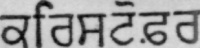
ਕਰਿਸਟੋਫ਼ਰ
